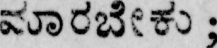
ಮಾರಬೇಕು;
